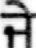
ਜੇ
